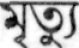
মৃত্যু
